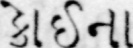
કોઈના
